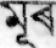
মূৰ
